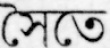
সৈতে
